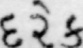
દરેક
